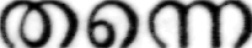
തന്നെ
